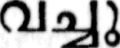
വച്ചു
